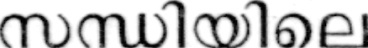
സന്ധിയിലെ
